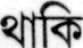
থাকি
